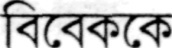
বিবেককে
